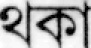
থকা
